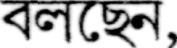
বলছেন,
